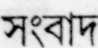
সংবাদ
